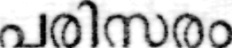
പരിസരം
